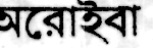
অরোইবা
